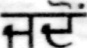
ਜਦੋਂ
